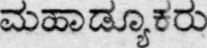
ಮಹಾಡ್ಯೂಕರು
